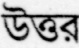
উত্তর
